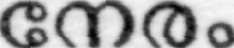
നേരം
